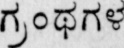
ಗ್ರಂಥಗಳ
